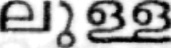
ലുള്ള
